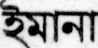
ইমানা
